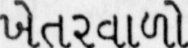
ખેતરવાળો
